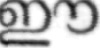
ഈ
